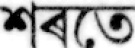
শৰতে
